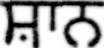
ਸ਼ਾਨ
